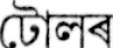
টোলৰ
